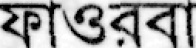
ফাওরবা
